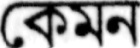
কেমন
